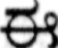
ಈ
